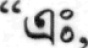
"এঃ,
